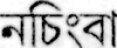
নচিংবা
